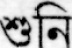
শুনি
